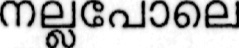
നല്ലപോലെ
